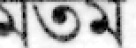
মতম
